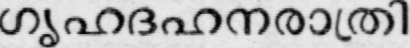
ഗൃഹദഹനരാത്രി
